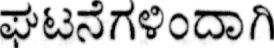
ಘಟನೆಗಳಿಂದಾಗಿ
